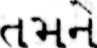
તમને
